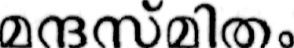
മന്ദസ്മിതം
